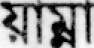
য়াম্না
